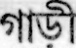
গাড়ী
